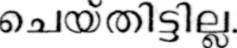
ചെയ്തിട്ടില്ല.
